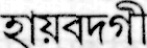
হায়বদগী
